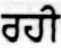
ਰਹੀ
